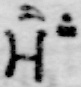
ਮੈਂ
